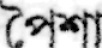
পৈশা
